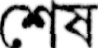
শেষ
